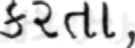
કરતા,
